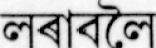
লৰাবলৈ
